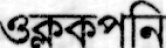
ওক্লকপনি
